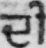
ਦੀ
